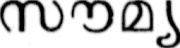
സൌമ്യ
